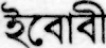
ইবোবী
